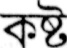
কষ্ট
